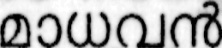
മാധവന്‍
